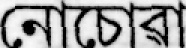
নোচোৱা
